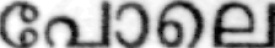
പോലെ
